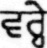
ਵਰ੍ਹੇ
